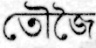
তৌজৈ
